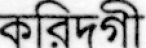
করিদগী
